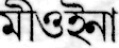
মীওইনা
